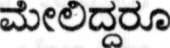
ಮೇಲಿದ್ದರೂ
